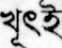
খূৎই
